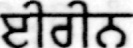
ਈਰੀਨ
